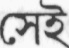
সেই
